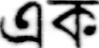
এক
